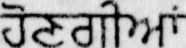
ਹੋਣਗੀਆਂ
